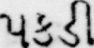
પકડી
